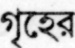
গৃহের
